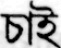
চাই
